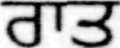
ਰਾਤ
